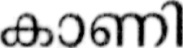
കാണി
